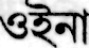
ওইনা
